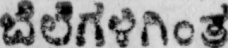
ಬೆಲೆಗಳಿಗಿಂತ
